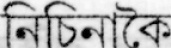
নিচিনাকৈ
